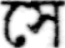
সে
